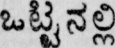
ಒಟ್ಟಿನಲ್ಲಿ
